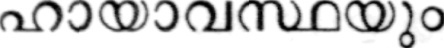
ഹായാവസ്ഥയും
